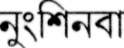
নুংশিনবা
